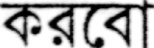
করবো
